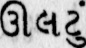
ઊલટું
